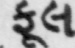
ફૂલ
